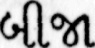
બીજા
